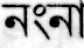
নংনা
